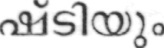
ഷ്ടിയും
